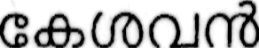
കേശവന്‍
